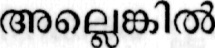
അല്ലെങ്കില്‍
